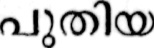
പുതിയ
